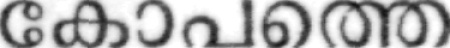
കോപത്തെ
